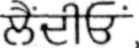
ਲੈਂਦੀਓਂ,
